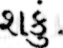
શકું.
